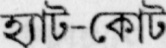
হ্যাট-কোট
